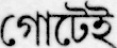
গোটেই
